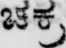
ಚಕ್ರ
